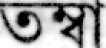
তম্বা
